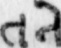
તને
